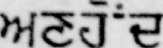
ਅਣਹੋਂਦ
